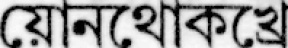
য়োনথোকখ্রে
